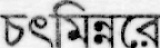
চৎমিন্নবা
